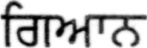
ਗਿਆਨ
